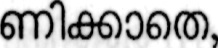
ണിക്കാതെ,
